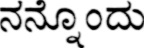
ನನ್ನೊಂದು
